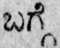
ಬಗ್ಗೆ
